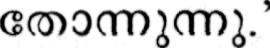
തോന്നുന്നു.’
